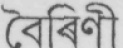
বৈৰিণী
